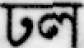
ঢল
